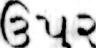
ઉપર
